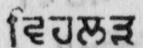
ਵਿਹਲੜ
